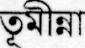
তূমীন্না
